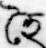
হৈ
